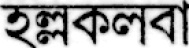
হল্লকলবা
